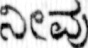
ನೀವು
